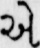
એ
